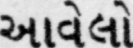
આવેલો
